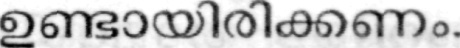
ഉണ്ടായിരിക്കണം.
